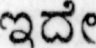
ಇದೇ
